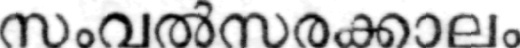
സംവല്‍സരക്കാലം
